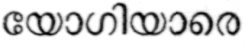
യോഗിയാരെ
